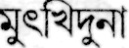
মুৎখিদুনা
